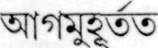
আগমুহূৰ্তত
